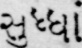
સુધ્ધાં
